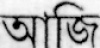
আজি
